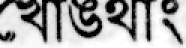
খোঙথাং
